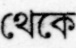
থেকে
